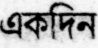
একদিন
